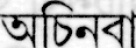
অচিনবা
